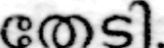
തേടി.
